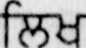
ਲਿਖ
